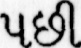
પછી
